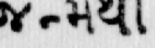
જન્મથી
